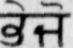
ਭੇਜੋ
